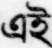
এই
